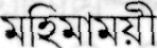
মহিমাময়ী
